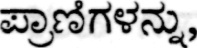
ಪ್ರಾಣಿಗಳನ್ನು,
